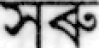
সৰু
